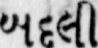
બદલી
